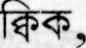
ক্বিক,
